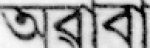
অৱাবা
